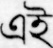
এই
